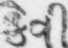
કેવી
